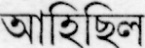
আহিছিল
